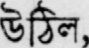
উঠিল,
